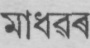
মাধৱৰ
